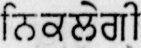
ਨਿਕਲੇਗੀ
